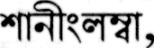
শানীংলম্বা,
